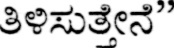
ತಿಳಿಸುತ್ತೇನೆ"
